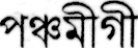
পঞ্চমীগী
